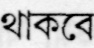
থাকবে
